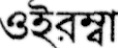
ওইরম্বা
